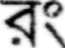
রং
